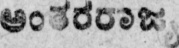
ಅಂತರರಾಜ್ಯ
